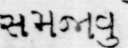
સમજાવું
